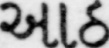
આઠ
